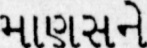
માણસને
